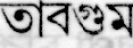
তাবগুম
